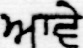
ਆਵੇ
